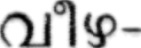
വീഴ-
